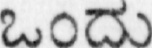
ಒಂದು
